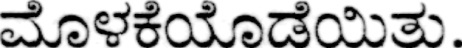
ಮೊಳಕೆಯೊಡೆಯಿತು.
